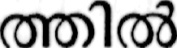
ത്തില്‍
